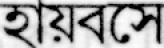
হায়বসে
